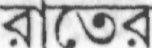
রাতের
